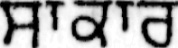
ਸਾਕਾਰ
